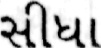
સીધા
